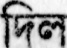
দিল
